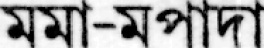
মমা-মপাদা
